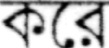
করে
